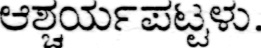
ಆಶ್ಚರ್ಯಪಟ್ಟಳು.
